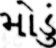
મોડું
